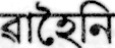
ৱাহৈনি
